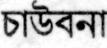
চাউবনা
